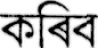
কৰিব
